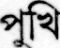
পুখি
